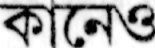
কানেও
